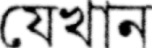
যেখান
